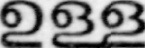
ഉള്ള
